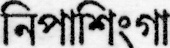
নিপাশিংগা
